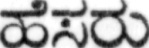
ಹೆಸರು
